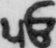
ਪਓ
